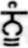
ਨੂੰ
